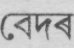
বেদৰ
